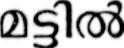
മട്ടില്‍
